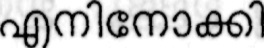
എനിനോക്കി
